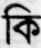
কি
